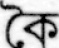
কৈ
